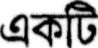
একটি
